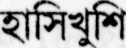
হাসিখুশি
